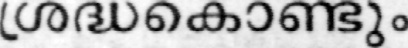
ശ്രദ്ധകൊണ്ടും
